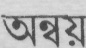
অন্বয়
